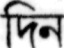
দিন
